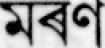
মৰণ
